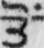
ਤੋਂ
